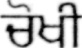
ਚੋਖੀ
